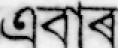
এবাৰ
